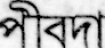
পীবদা
